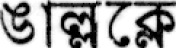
ঙাল্লক্লে
